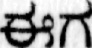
ಈಗ
